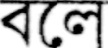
বলে
